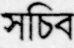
সচিব
